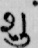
શું
